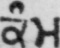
ਕੰਮ
